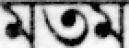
মতম
